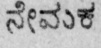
ನೇಮಕ
